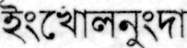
ইংখোলনুংদা
